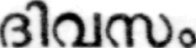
ദിവസം
